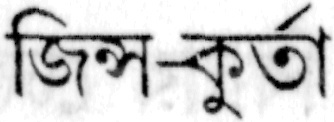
জিন্স-কুর্তা
